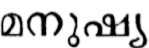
മനുഷ്യ
